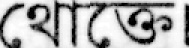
থোক্তে।
